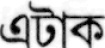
এটাক
